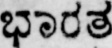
ಭಾರತ
